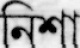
নিশা
